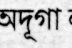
অদূগা
